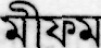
মীফম
